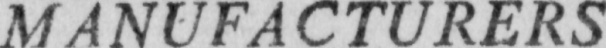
MANUFACTUTERS
